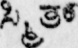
ಸ್ಮಿತ್
